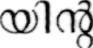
യിന്റ
